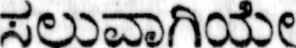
ಸಲುವಾಗಿಯೇ
